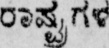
ರಾಷ್ಟ್ರಗಳ
